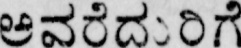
ಅವರೆದುರಿಗೆ
